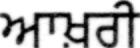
ਆਖ਼ਰੀ
